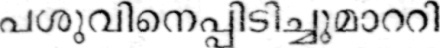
പശുവിനെപ്പിടിച്ചുമാററി
